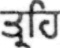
ਤ੍ਰਹਿ
